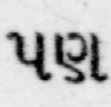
પણ
